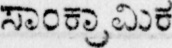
ಸಾಂಕ್ರಾಮಿಕ
